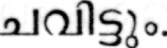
ചവിട്ടും.
